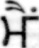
ਮੈਂ
